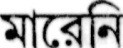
মারেনি
